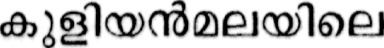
കുളിയന്‍മലയിലെ
